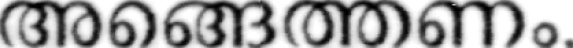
അങ്ങെത്തണം.
